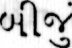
બીજું
